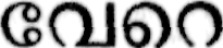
വേറെ
